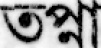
তপ্না
